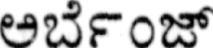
ಅರ್ಬೆಂಜ್
